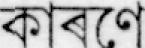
কাৰণে
